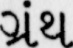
ગ્રંથ
